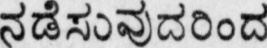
ನಡೆಸುವುದರಿಂದ
